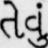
તેવું
